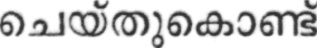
ചെയ്തുകൊണ്ട്
